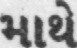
માથે
